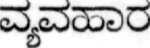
ವ್ಯವಹಾರ
